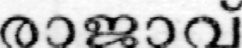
രാജാവ്
